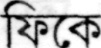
ফিকে
